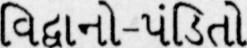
વિદ્વાનો-પંડિતો
